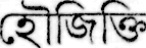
হৌজিক্তি
